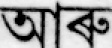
আৰু
